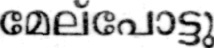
മേല്പോട്ടു
